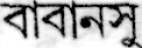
বাবানসু
